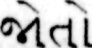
જોતો
